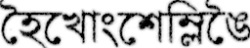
হৈখোংশেম্লিঙৈ
